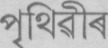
পৃথিৱীৰ
